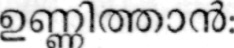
ഉണ്ണിത്താന്‍:
